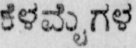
ಕೆಳಮೈಗಳ
